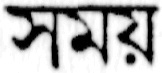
সময়
